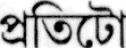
প্রতিটো
